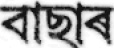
বাছাৰ
